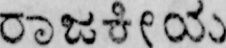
ರಾಜಕೀಯ
